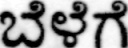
ಬೆಳೆಗೆ
